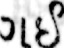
ગઈ
